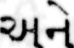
અને
